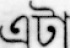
এটা
